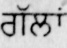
ਗੱਲਾਂ
